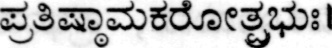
ಪ್ರತಿಷ್ಠಾಮಕರೋತ್ಪ್ರಭುಃ|
